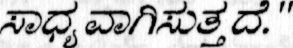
ಸಾಧ್ಯವಾಗಿಸುತ್ತದೆ.”
